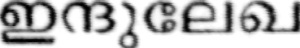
ഇന്ദുലേഖ
